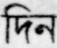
দিন
